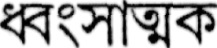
ধ্বংসাত্মক
